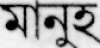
মানুহ
